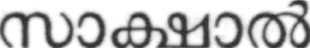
സാക്ഷാല്‍
